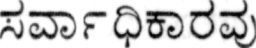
ಸರ್ವಾಧಿಕಾರವು
